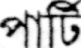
পার্টি
